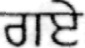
ਗਏ
